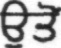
ਉਤੋਂ
